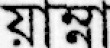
য়াম্না
